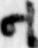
ન
